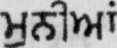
ਮੁਨੀਆਂ
